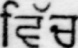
ਵਿੱਚ
